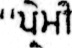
''ਪ੍ਰੇਮੀ
